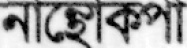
নান্থোকপা
